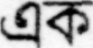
এক
